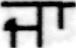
ਜਾ
